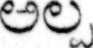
ಅಲ್ಪ
